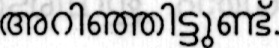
അറിഞ്ഞിട്ടുണ്ട്.
